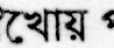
ঐখোয়
